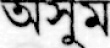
অসুম
